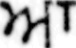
ਆ
